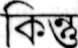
কিন্তু
